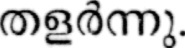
തളര്‍ന്നു.
